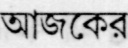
আজকের
